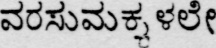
ವರಸುಮಕ್ಕಳಲೇ
